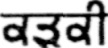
ਕੜਕੀ
